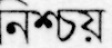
নিশ্চয়
